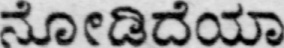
ನೋಡಿದೆಯಾ
